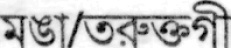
মঙা/তরুক্তগী
